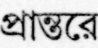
প্রান্তরে
